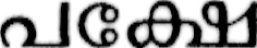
പക്ഷേ
